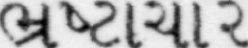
ભ્રષ્ટાચાર
